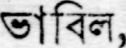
ভাবিল,
